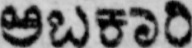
ಅಬಕಾರಿ
